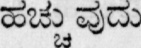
ಹಚ್ಚುವುದು
